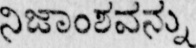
ನಿಜಾಂಶವನ್ನು
